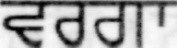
ਵਰਗਾ
